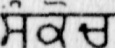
ਸੰਕੋਚ
